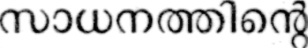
സാധനത്തിന്റെ
